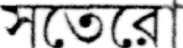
সতেরো
